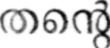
തന്റെ
